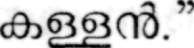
കള്ളന്‍."
